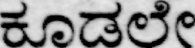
ಕೂಡಲೇ
